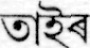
তাইৰ
